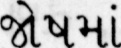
જોષમાં
